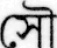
সৌ
